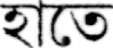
হাতে
